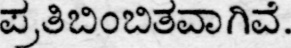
ಪ್ರತಿಬಿಂಬಿತವಾಗಿವೆ.
